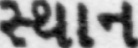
સ્થાન
